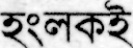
হংলকই
